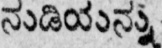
ನುಡಿಯನ್ನು
